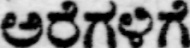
ಅರೆಗಳಿಗೆ
